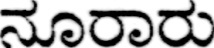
ನೂರಾರು
